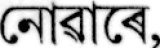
নোৱাৰে,
